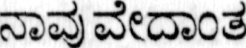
ನಾವುವೇದಾಂತ
